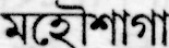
মহৌশাগা
